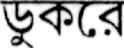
ডুকরে
